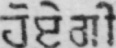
ਹੋਏਗੀ
